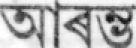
আৰম্ভ
